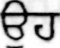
ਉਹ
